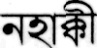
নহাক্কী
